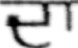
ਦਾ
